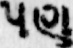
પણ
